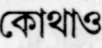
কোথাও
